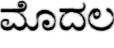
ಮೊದಲ
